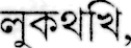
লুকথখি,
